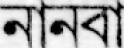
নানবা
